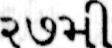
૨૭મી
